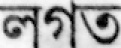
লগত
